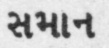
સમાન
